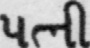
પત્ની
